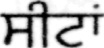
ਸੀਟਾਂ
